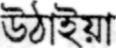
উঠাইয়া
